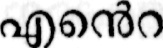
എന്റെ
